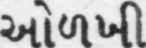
ઓળખી
